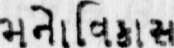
મનોવિકાસ
